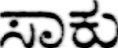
ಸಾಕು
